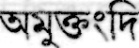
অমুক্তংদি
